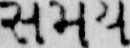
સમય
